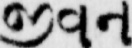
જીવન
